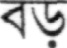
বড়
